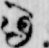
છે.
